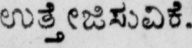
ಉತ್ತೇಜಿಸುವಿಕೆ.
